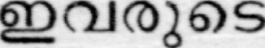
ഇവരുടെ
